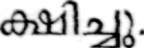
ക്ഷിച്ചു.
